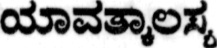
ಯಾವತ್ಕಾಲಸ್ಯ
